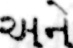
અને
